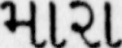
મારા
